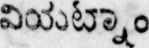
ವಿಯಟ್ನಾಂ
